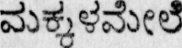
ಮಕ್ಕಳಮೇಲೆ
